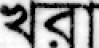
খরা
